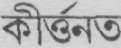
কীৰ্ত্তনত
